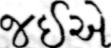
જઈએ
